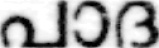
പാദ
